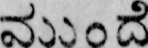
ಮುಂದೆ
